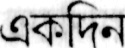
একদিন
